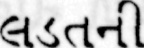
લડતની
